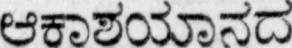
ಆಕಾಶಯಾನದ
